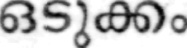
ഒടുക്കം
